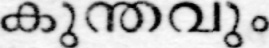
കുന്തവും
